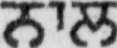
ਨਾਲ
